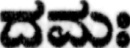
ದಮಃ
